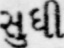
સુધી
